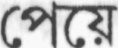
পেয়ে
